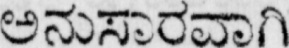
ಅನುಸಾರವಾಗಿ
